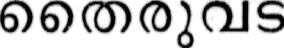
തൈരുവട
